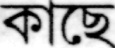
কাছে
